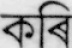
কৰি
